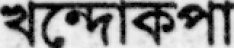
খন্দোকপা
